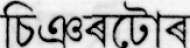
চিঞৰটোৰ
